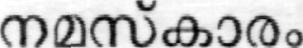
നമസ്കാരം
